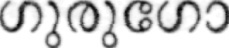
ഗുരുഗോ
